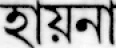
হায়না
